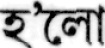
হ'লো
